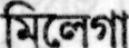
মিলেগা
